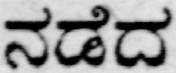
ನಡೆದ
